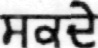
ਸਕਦੇ
